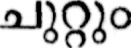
ചുറ്റും
